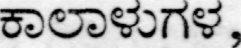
ಕಾಲಾಳುಗಳ,
